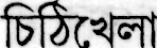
চিঠিখেলা
